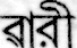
ৱারী
